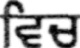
ਵਿਚ
